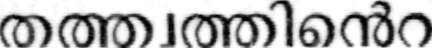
തത്ത്വത്തിന്റെ
